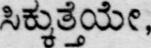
ಸಿಕ್ಕುತ್ತೆಯೇ,
